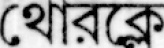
থোরক্লে
